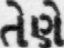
તેણે
